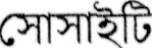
সোসাইটি
